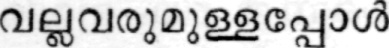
വല്ലവരുമുള്ളപ്പോള്‍
